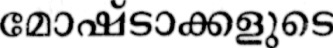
മോഷ്ടാക്കളുടെ
